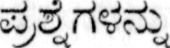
ಪ್ರಶ್ನೆಗಳನ್ನು
